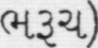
ભરૂચ)
